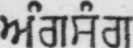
ਅੰਗਸੰਗ
